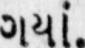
ગયાં.
